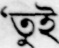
‘তুই
